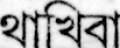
থাখিবা
